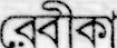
রেবীকা
